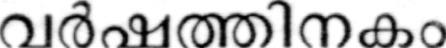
വര്‍ഷത്തിനകം
